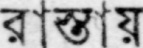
রাস্তায়
